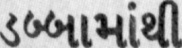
ડબ્બામાંથી
